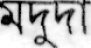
মদুদা
